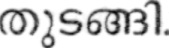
തുടങ്ങി.
